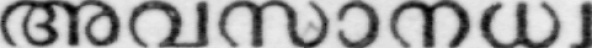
അവസാനധ്വ
